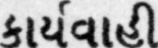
કાર્યવાહી
